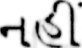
નહીં
